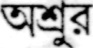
অশ্রুর
